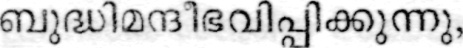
ബുദ്ധിമന്ദിഭവിപ്പിക്കുന്നു,
